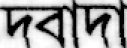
দবাদা
